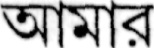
আমার
